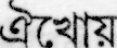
ঐখোয়
